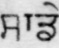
ਸਾਡੇ
